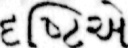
દષ્ટિએ
